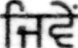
ਜਿਵੇਂ
